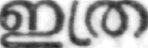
ഇത്ര
